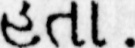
હતા.
